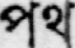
পথ
